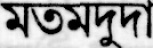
মতমদুদা
